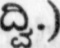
ದ್ವಿ)
